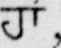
ਹਾਂ,
